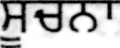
ਸੂਚਨਾ
